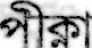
পীক্না
